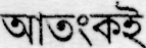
আতংকই
